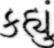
કહ્યું
